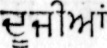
ਦੂਜੀਆਂ
